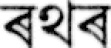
ৰথৰ
